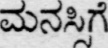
ಮನಸ್ಸಿಗೆ
